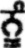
ਨੂੰ
